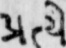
પ્રત્યે
